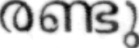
രണ്ടു
